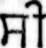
ਸੀ
